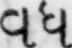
વધ
